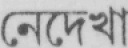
নেদেখা
